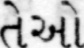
તેઓ
